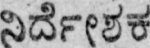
ನಿರ್ದೇಶಕ
